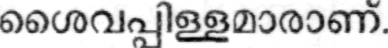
ശൈവപ്പിള്ളമാരാണ്.
